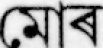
মোৰ
